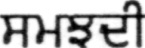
ਸਮਝਦੀ
